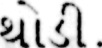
થોડી.
